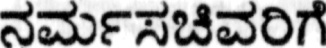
ನರ್ಮಸಚಿವರಿಗೆ
